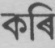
কৰি
